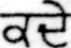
ਕਦੇ
